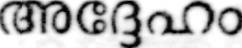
അദ്ദേഹം
